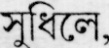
সুধিলে,
